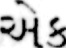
એક
